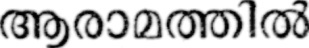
ആരാമത്തില്‍
